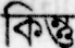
কিন্তু
